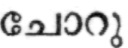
ചോറു
